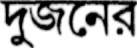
দুজনের
